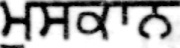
ਮੁਸਕਾਨ
